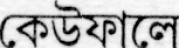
কেউফালে
